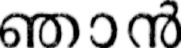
ഞാന്‍
